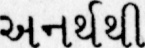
અનર્થથી
